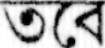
তবে
